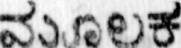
ಮೂಲಕ
